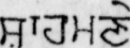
ਸਾਹਮਣੇ
